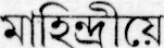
মাহিন্দ্রীয়ে
